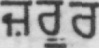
ਜ਼ਰੂਰ
